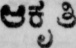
ಆಕೃತಿ
